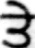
ਤੇ
